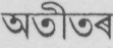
অতীতৰ
